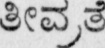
ತೀವ್ರತೆ
